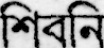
শিবনি
